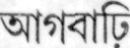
আগবাঢ়ি
